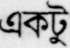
একটু
